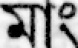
মাং
